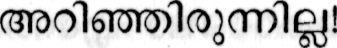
അറിഞ്ഞിരുന്നില്ല!
